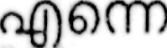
എന്നെ
